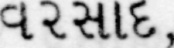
વરસાદ,
